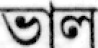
ভাল
